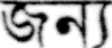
জন্য
